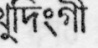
খুদিংগী
